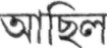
আছিল
